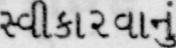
સ્વીકારવાનું
